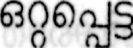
ഒറ്റപ്പെട്ട
